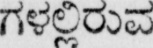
ಗಳಲ್ಲಿರುವ
